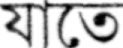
যাতে
